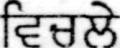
ਵਿਚਲੇ
